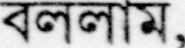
বললাম,
